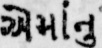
એમાંનું
